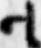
ન
